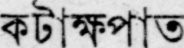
কটাক্ষপাত
